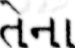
તેના
